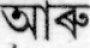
আৰু
